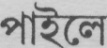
পাইলে
